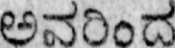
ಅವರಿಂದ
